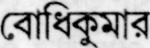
বোধিকুমার
